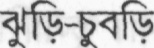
ঝুড়ি-চুবড়ি
